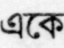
একে
